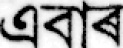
এবাৰ
